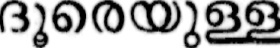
ദൂരെയുള്ള
